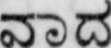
ವಾದ
